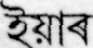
ইয়াৰ
